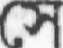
সে
